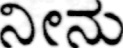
ನೀನು
